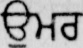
ਉਮਰ
